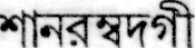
শানরম্বদগী
